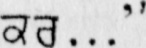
ਕਰ.....''
